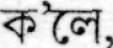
ক'লে,
